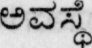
ಅವಸ್ಥೆ
